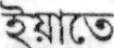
ইয়াতে
